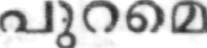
പുറമെ
